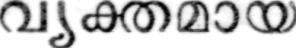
വ്യക്തമായ
